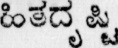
ಹಿತದೃಷ್ಟಿ
